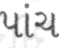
પાંચ
